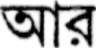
আর
